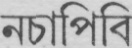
নচাপিবি
